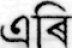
এৰি
